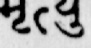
મૃત્યુ
